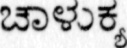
ಚಾಳುಕ್ಯ
